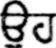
ਉਹ
